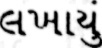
લખાયું
